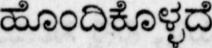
ಹೊಂದಿಕೊಳ್ಳದೆ
